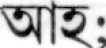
আহ;
